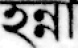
হন্না
